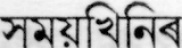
সময়খিনিৰ
